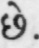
છે.
